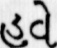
હવે
